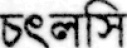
চৎলসি
